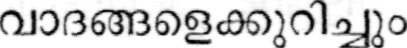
വാദങ്ങളെക്കുറിച്ചും
